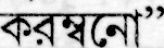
করম্বনো”
